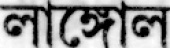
লাঙ্গোল
